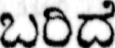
ಬರಿದೆ
